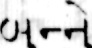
બન્ને
